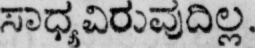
ಸಾಧ್ಯವಿರುವುದಿಲ್ಲ.
